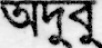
অদুবু
